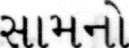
સામનો
